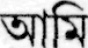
আমি
